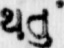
અમને
